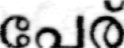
പേര്
